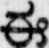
ಈ
